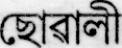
ছোৱালী
